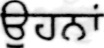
ਉਹਨਾਂ
